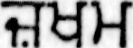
ਜ਼ਖਮ
